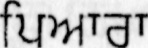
ਪਿਆਰਾ
